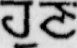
ਹੁਣ
